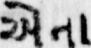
એના
